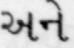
અને
